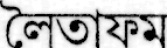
লৈতাফম
